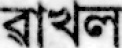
ৱাখল
